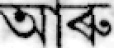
আৰু
